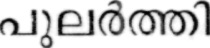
പുലര്‍ത്തി
